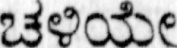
ಚಳಿಯೇ
